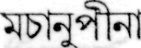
মচানুপীনা
